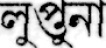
লুপ্তুনা
